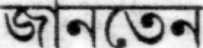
জানতেন
